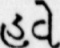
હવે
